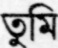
তুমি
